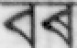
বৰ
